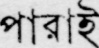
পারাই
